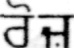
ਰੋਜ਼
